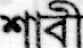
শাবী
